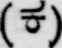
(ಕ)
